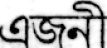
এজনী
